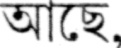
আছে,
